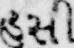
હસી
